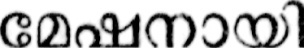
മേഷനായി
